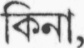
কিনা,
